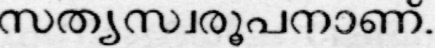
സത്യസ്വരൂപനാണ്.
